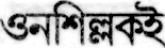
ওনশিল্লকই
